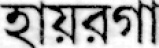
হায়রগা
